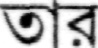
তার
